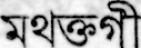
মথক্তগী
